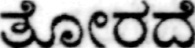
ತೋರದೆ
